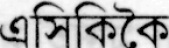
এসিকিকৈ
